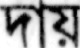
দায়
